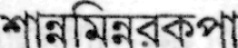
শান্নমিন্নরকপা
